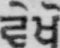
ਵੇਖੋ
